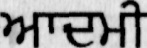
ਆਦਮੀ
